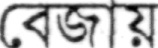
বেজায়
